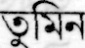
তুমিন
